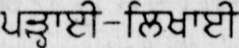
ਪੜ੍ਹਾਈ-ਲਿਖਾਈ
